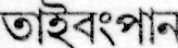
তাইবংপান
